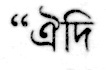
“ঐদি
